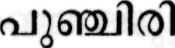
പുഞ്ചിരി
